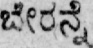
ಬೇರನ್ನೆ
